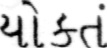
યોક્તં
